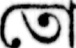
তো
